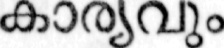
കാര്യവും
